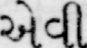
એવી
